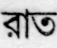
রাত
